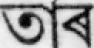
তাৰ
